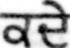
ਕਦੇ
